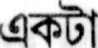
একটা
